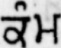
ਕੰਮ
